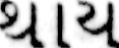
થાય
